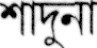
শাদুনা
